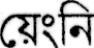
য়েংনি
